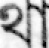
থা
